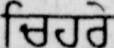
ਚਿਹਰੇ
